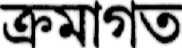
ক্রমাগত
